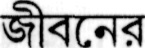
জীবনের
